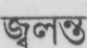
জ্বলন্ত
